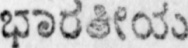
ಭಾರತೀಯ
